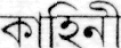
কাহিনী
